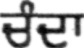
ਚੰਦਾ
